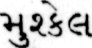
મુશ્કેલ
